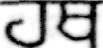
ਹਥ
